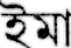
ইমা
